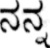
ನನ್ನ
